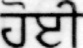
ਹੋਈ
